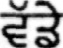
ਵੱਡੇ
